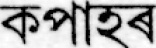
কপাহৰ
